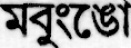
মবুংঙো
